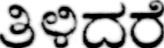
ತಿಳಿದರೆ
